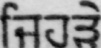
ਜਿਹੜੇ
